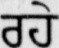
ਰਹੇ
